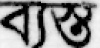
ব্যস্ত
